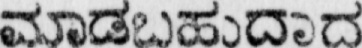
ಮಾಡಬಹುದಾದ
